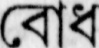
বোধ
